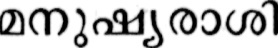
മനുഷ്യരാശി
